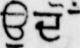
ਉਦੋਂ
